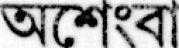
অশেংবা
